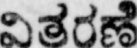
ವಿತರಣೆ
